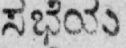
ಸಭೆಯ
